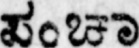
ಪಂಚಾ
